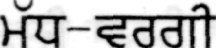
ਮੱਧ-ਵਰਗੀ
